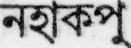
নহাকপু
